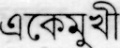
একেমুখী
